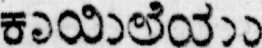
ಕಾಯಿಲೆಯು
